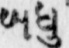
બધું
